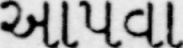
આપવા
